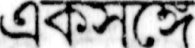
একসঙ্গে
